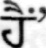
ਹੈਂ'
